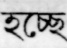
হচ্ছে
